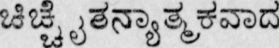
ಚಿಚ್ಚೈತನ್ಯಾತ್ಮಕವಾದ
